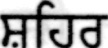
ਸ਼ਹਿਰ
